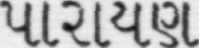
પારાયણ
